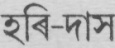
হৰি-দাস
